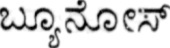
ಬ್ಯೂನೋಸ್
